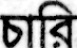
চারি
